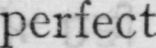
perfect
